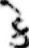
કે
